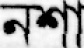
নশা
